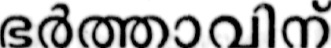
ഭര്‍ത്താവിന്
